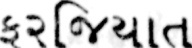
ફરજિયાત
